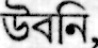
উবনি,
